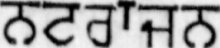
ਨਟਰਾਜਨ
